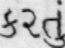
કરતું
